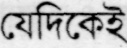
যেদিকেই
